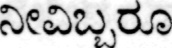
ನೀವಿಬ್ಬರೂ
